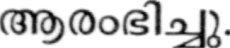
ആരംഭിച്ചു.
